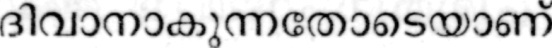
ദിവാനാകുന്നതോടെയാണ്
